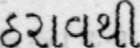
ઠરાવથી
